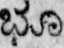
ಭೂ
